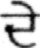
ਦੇ
